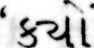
'ક્યોં
